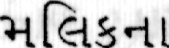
મલિકના
